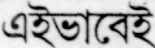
এইভাবেই
